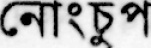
নোংচুপ
